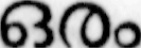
ഒരം
